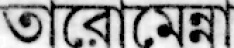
তারোমেন্না
